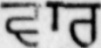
ਵਾਰ
